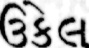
ઉકેલ
